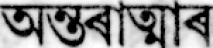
অন্তৰাত্মাৰ
